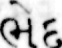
ભેદ
